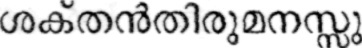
ശക്തന്‍തിരുമനസ്സു
